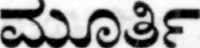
ಮೂರ್ತಿ
